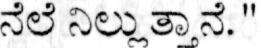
ನೆಲೆನಿಲ್ಲುತ್ತಾನೆ.”
